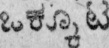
ಒಕ್ಕೂಟ
